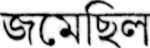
জমেছিল
